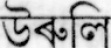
উৰুলি
